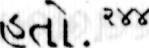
હતો.૨૪૪
